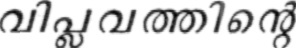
വിപ്ലവത്തിന്റെ
